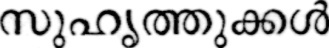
സുഹൃത്തുക്കള്‍
